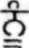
ਨੂੰ
